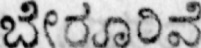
ಬೇರೂರಿವೆ
